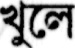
খুলে
